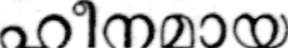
ഹീനമായ
